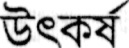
উৎকর্ষ
